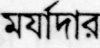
মর্যাদার
